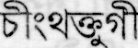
চীংথক্তুগী
